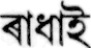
ৰাধাই
